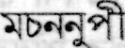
মচননুপী
